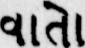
વાતો
